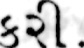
કરી.
